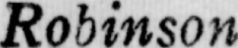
Robinson
